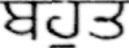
ਬਹੁਤ
